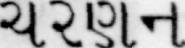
ચરણન
